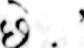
છે.'
